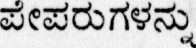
ಪೇಪರುಗಳನ್ನು
